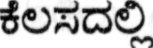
ಕೆಲಸದಲ್ಲಿ
